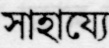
সাহায্যে
